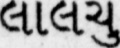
લાલચુ
